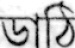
ডাঠি
